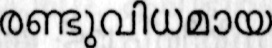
രണ്ടുവിധമായ
